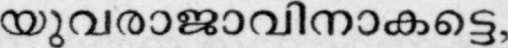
യുവരാജാവിനാകട്ടെ,
